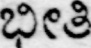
ಭೀತಿ
